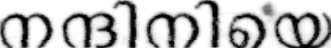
നന്ദിനിയെ
